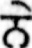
ਨੇ
